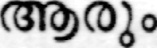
ആരും
